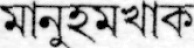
মানুহমখাক
